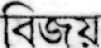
বিজয়
